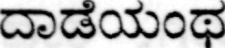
ದಾಡೆಯಂಥ
